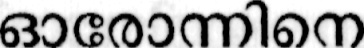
ഓരോന്നിനെ
